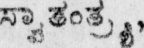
ಸ್ವಾತಂತ್ರ್ಯ,
